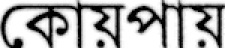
কোয়পায়
